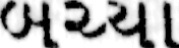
બચ્યા
